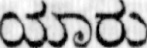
ಯಾರು
